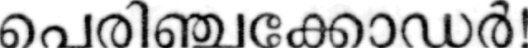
പെരിഞ്ചക്കോഡര്‍!
